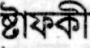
ষ্টাফকী
